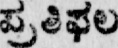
ಪ್ರತಿಫಲ
